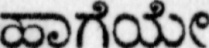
ಹಾಗೆಯೇ
